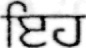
ਇਹ
